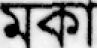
মকা
